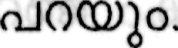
പറയും.
